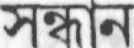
সন্ধান
